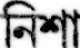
নিশা
